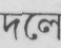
দলে
